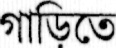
গাড়িতে
